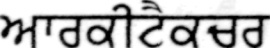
ਆਰਕੀਟੈਕਚਰ
